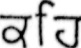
ਕਹਿ
